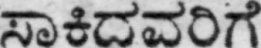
ಸಾಕಿದವರಿಗೆ
